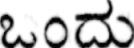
ಒಂದು
